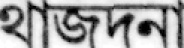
থাজদনা
